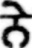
ਨੇ
